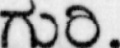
ಗುರಿ.
